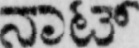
ನಾಟ್
